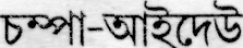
চম্পা-আইদেউ
